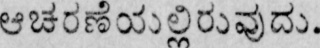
ಆಚರಣೆಯಲ್ಲಿರುವುದು.
